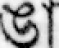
ঙা
